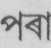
পৰা
